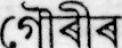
গৌৰীৰ
